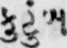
કુંટુંબ
